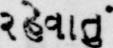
રહેવાતું
